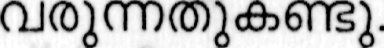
വരുന്നതുകണ്ടു.
